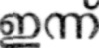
ഇന്ന്
